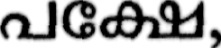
പക്ഷേ,
